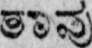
ತಾವು
